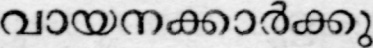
വായനക്കാര്‍ക്കു
